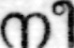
നീ
